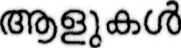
ആളുകള്‍
